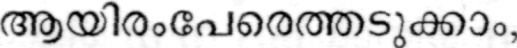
ആയിരംപേരെത്തടുക്കാം,
